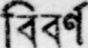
বিবর্ণ
